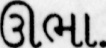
ઊભા.
